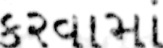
કરવામાં
